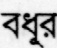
বধূর
